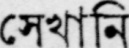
সেখানি
